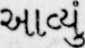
આવ્યું
